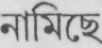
নামিছে
